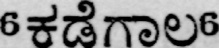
6ಕಡೆಗಾಲ6
